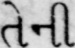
તેની
